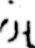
બે
